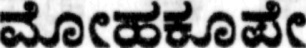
ಮೋಹಕೂಪೇ
